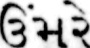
ઉંમરે
